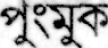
পুংমুক
